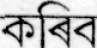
কৰিব
